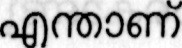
എന്താണ്
